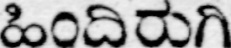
ಹಿಂದಿರುಗಿ
